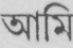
আমি
